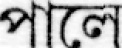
পালে
